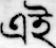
এই
